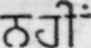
ਨਹੀਂ
